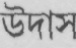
উদাস
